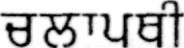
ਚਲਾਪਥੀ
